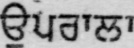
ਉਪਰਾਲਾ
